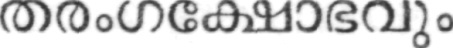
തരംഗക്ഷോഭവും
